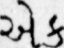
એક
